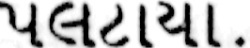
પલટાયા.
